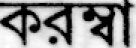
করম্বা
